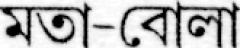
মতা-বোলা
